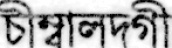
চীম্বালদগী
